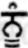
ਨੂੰ
